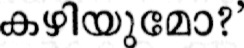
കഴിയുമോ?’
